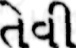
તેવી
